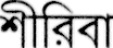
শীরিবা
